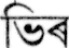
ভিৰ
